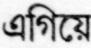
এগিয়ে
